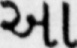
આ
